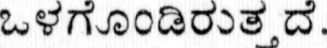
ಒಳಗೊಂಡಿರುತ್ತದೆ.
